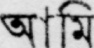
আমি
